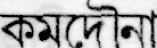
কমদৌনা
